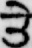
ਤੇ
